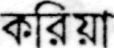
করিয়া
